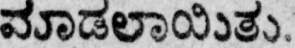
ಮಾಡಲಾಯಿತು.
